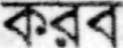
করব
